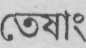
তেষাং
